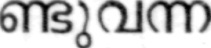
ണ്ടുവന്ന
